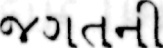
જગતની
